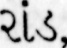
રાંડ,
